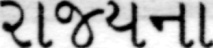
રાજ્યના
